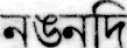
নঙনদি
